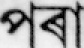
পৰা
